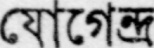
যোগেন্দ্র
